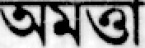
অমত্তা
